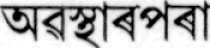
অৱস্হাৰপৰা
